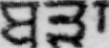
ਬੜਾ
